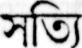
সত্যি
